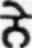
ਨੇ
